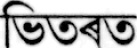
ভিতৰত
